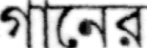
গানের
